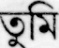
তুমি
